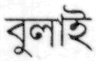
বুলাই
